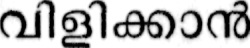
വിളിക്കാന്‍
